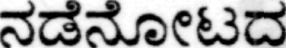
ನಡೆನೋಟದ
